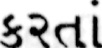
કરતાં
